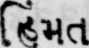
હિંમત
